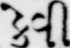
કેવી
